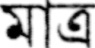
মাত্র
